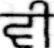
ਵੀ
